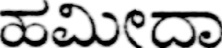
ಹಮೀದಾ
